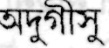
অদুগীসু
